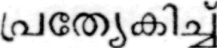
പ്രത്യേകിച്ച്
